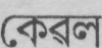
কেৱল
